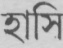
হাসি
